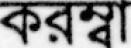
করম্বা
